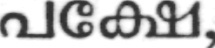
പക്ഷേ,
